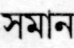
সমান
